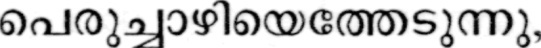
പെരുച്ചാഴിയെത്തേടുന്നു,
